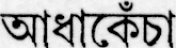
আধাকেঁচা
